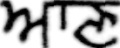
ਆਣ
